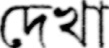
দেখা
